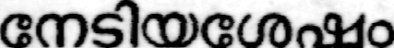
നേടിയശേഷം
